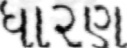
ધારણ
